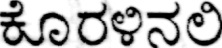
ಕೊರಳಿನಲಿ
